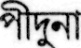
পীদুনা
